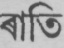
ৰাতি
